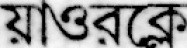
য়াওরক্লে
